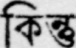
কিন্তু
